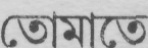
তোমাতে
